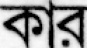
কার
